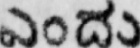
ಎಂದು
